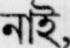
নাই,
